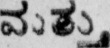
ಮತ್ತು
